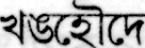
খঙহৌদে
